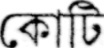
কোটি
